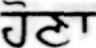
ਹੋਣਾ
